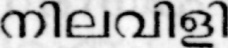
നിലവിളി
